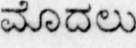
ಮೊದಲು
